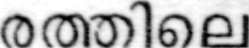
രത്തിലെ
